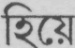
হিয়ে
